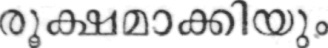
രൂക്ഷമാക്കിയും
